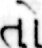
તો
